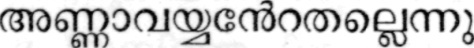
അണ്ണാവയ്യന്റേതല്ലെന്നു
